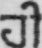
ਹੀ
